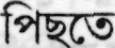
পিছতে
